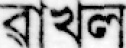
ৱাখল
